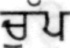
ਚੁੱਪ
